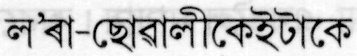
ল'ৰা-ছোৱালীকেইটাকে
